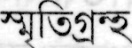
স্মৃতিগ্রন্হ
